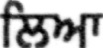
ਲਿਆ
